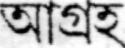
আগ্রহ
